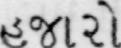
હજારો
